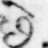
છે.
